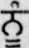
ਨੂੰ
